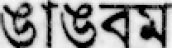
ঙাঙবম
